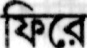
ফিরে
